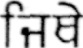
ਜਿਥੇ
